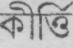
কীৰ্ত্তি
